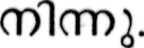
നിന്നു.
